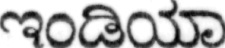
ಇಂಡಿಯಾ
